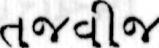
તજવીજ
